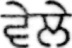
ਵੇਲੇ
